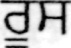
ਰੂਸ
